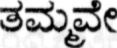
ತಮ್ಮವೇ
